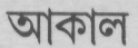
আকাল
